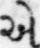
એ
